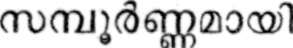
സമ്പൂര്‍ണ്ണമായി
